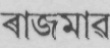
ৰাজমাৱ
